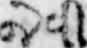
જેવી
